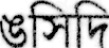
ঙসিদি
